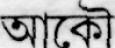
আকৌ
